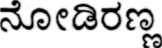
ನೋಡಿರಣ್ಣ
